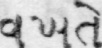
વખતે
